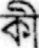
কী
